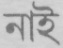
নাই
